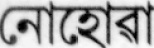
নোহোৱা
